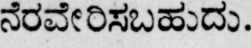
ನೆರವೇರಿಸಬಹುದು.
